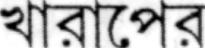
খারাপের
